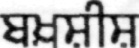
ਬਖ਼ਸ਼ੀਸ਼
